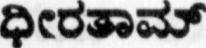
ಧೀರತಾಮ್
